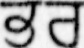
ਭਰ
